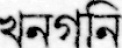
খনগনি
